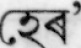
হেৰ'
